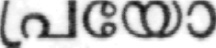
പ്രയോ
